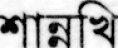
শান্নখি
